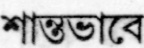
শান্তভাবে
